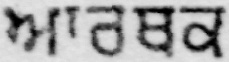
ਆਰਥਕ
